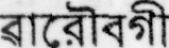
ৱারৌবগী
